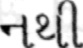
નથી
